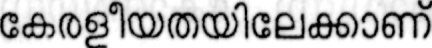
കേരളീയതയിലേക്കാണ്
